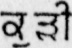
ਕੁੜੀ
